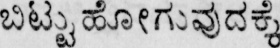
ಬಿಟ್ಟುಹೋಗುವುದಕ್ಕೆ
